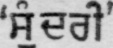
'ਸੁੰਦਰੀ'
